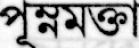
পূম্নমক্তা
